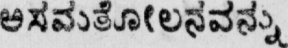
ಅಸಮತೋಲನವನ್ನು
